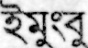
ইমুংবু
